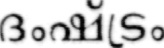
ദംഷ്ട്രം
